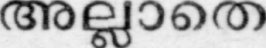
അല്ലാതെ
